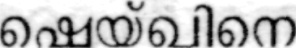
ഷെയ്ഖിനെ
